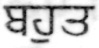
ਬਹੁਤ
